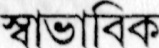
স্বাভাবিক
